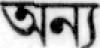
অন্য
